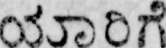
ಯಾರಿಗೆ
